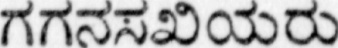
ಗಗನಸಖಿಯರು
